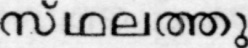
സ്ഥലത്തു
